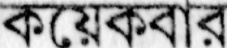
কয়েকবার
